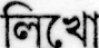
লিখো
